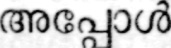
അപ്പോള്‍
